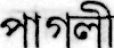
পাগলী
